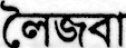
লৈজবা
